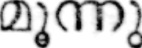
മൂന്നു
